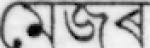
মেজৰ
